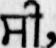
ਸੀ,
